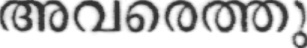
അവരെത്തു
